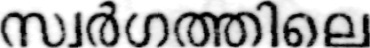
സ്വര്‍ഗത്തിലെ
